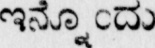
ಇನ್ನೊಂದು
